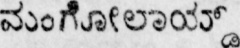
ಮಂಗೋಲಾಯ್ಡ್
